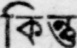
কিন্তু
